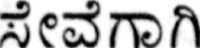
ಸೇವೆಗಾಗಿ
